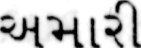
અમારી
